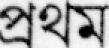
প্রথম
